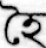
হৈ
